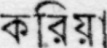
করিয়া
